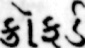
ક્રૉફર્ડ
